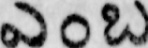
ಎಂಬ
